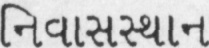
નિવાસસ્થાન
